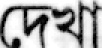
দেখা
